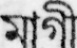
মাগী
